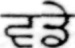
ਵਡੇ
